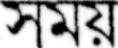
সময়
